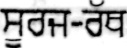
ਸੂਰਜ-ਰੱਥ
